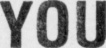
YOU
